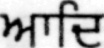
ਆਦਿ
